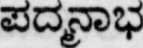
ಪದ್ಮನಾಭ
